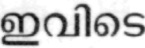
ഇവിടെ
